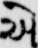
એ
